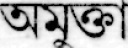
অমুক্তা
